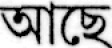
আছে
